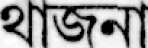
থাজনা
